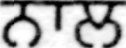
ਨਾਲ
